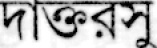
দাক্তরসু
